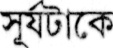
সূর্যটাকে
